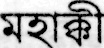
মহাক্কী
